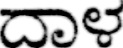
ದಾಳ
